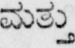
ಮತ್ತು
